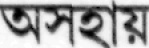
অসহায়
